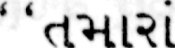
"તમારાં
